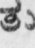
ತು
